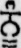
ਨੂੰ
